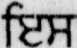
ਇਸ
